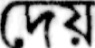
দেয়
